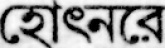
হোৎনরে
